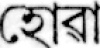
হোৱা
